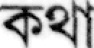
কথা
